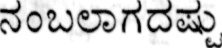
ನಂಬಲಾಗದಷ್ಟು
